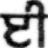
ਈ
